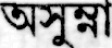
অসুম্না
